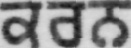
ਕਰਨ
